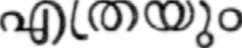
എത്രയും
